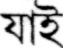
যাই
